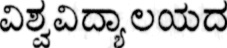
ವಿಶ್ವವಿದ್ಯಾಲಯದ
